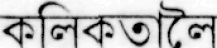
কলিকতালৈ
